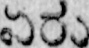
ಏರು
